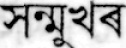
সন্মুখৰ
